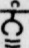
ਨੂੰ
